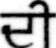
ਦੀ
